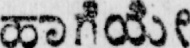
ಹಾಗೆಯೇ
